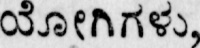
ಯೋಗಿಗಳು,
